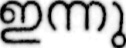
ഇന്നു
